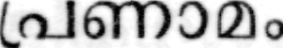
പ്രണാമം
